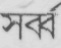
সৰ্ব্ব
